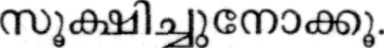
സൂക്ഷിച്ചുനോക്കൂ.
